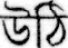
উঠি
